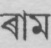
ৰাম
